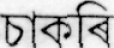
চাকৰি
